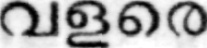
വളരെ
